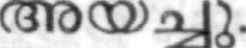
അയച്ചു.
